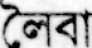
লৈবা
